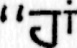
''ਹਾਂ
